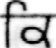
ਕਿ
